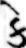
કે
